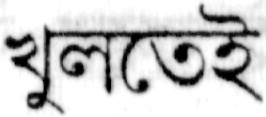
খুলতেই
